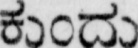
ಕುಂದು
